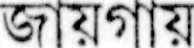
জায়গায়
